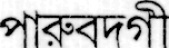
পারুবদগী
